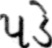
પડે
